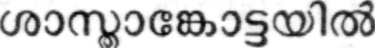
ശാസ്താങ്കോട്ടയില്‍
